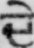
ਦੇ
